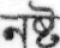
নষ্ট
